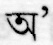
অ'
